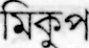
মিকুপ
